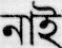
নাই
